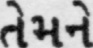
તેમને
